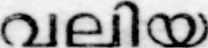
വലിയ
